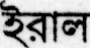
ইরাল
